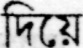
দিয়ে
